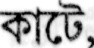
কাটে,
